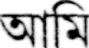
আমি
